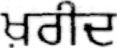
ਖ਼ਰੀਦ
